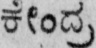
ಕೇಂದ್ರ
